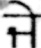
ਜੇ
